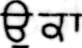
ਉਕਾ
